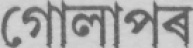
গোলাপৰ
